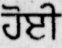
ਹੋਈ
